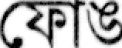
ফোঙ
